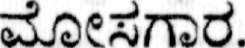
ಮೋಸಗಾರ.
